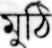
মুঠি
